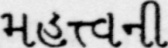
મહત્વની
